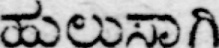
ಹುಲುಸಾಗಿ
